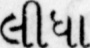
લીધા
